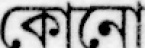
কোনো
